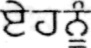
ਏਹਨੂੰ
